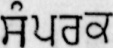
ਸੰਪਰਕ
